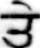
ਤੇ
